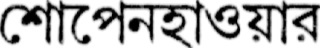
শোপেনহাওয়ার
